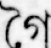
গৈ
